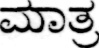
ಮಾತ್ರ
